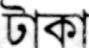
টাকা
